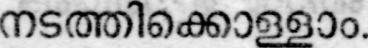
നടത്തിക്കൊള്ളാം.
